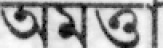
অমত্তা
